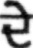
ਦੇ
